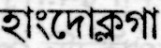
হাংদোক্লগা
